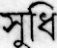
সুধি
